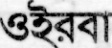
ওইরবা
